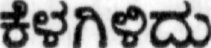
ಕೆಳಗಿಳಿದು
